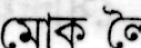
মোক
